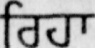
ਰਿਹਾ
